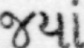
જ્યાં
